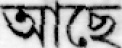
আছে
